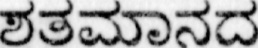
ಶತಮಾನದ
